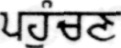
ਪਹੁੰਚਣ
